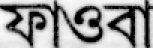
ফাওবা
